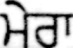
ਮੇਰਾ
